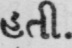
હતી.
